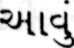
આવું
